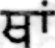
ਥਾਂ
